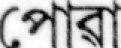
পোৱা
